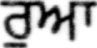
ਰੁਆ
